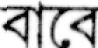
বাবে
